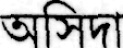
অসিদা
